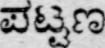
ಪಟ್ಟಣ
